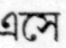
এসে
